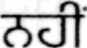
ਨਹੀਂ
